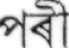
পৰী
